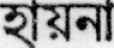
হায়না
